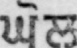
ਘੋਲ
